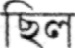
ছিল
